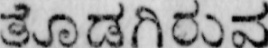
ತೊಡಗಿರುವ
